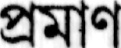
প্রমাণ
